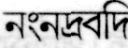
নংনদ্রবদি
